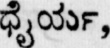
ಧೈರ್ಯ,
